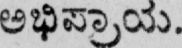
ಅಭಿಪ್ರಾಯ.
